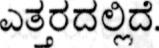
ಎತ್ತರದಲ್ಲಿದೆ.
